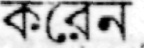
করেন
